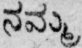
ನಮ್ಮ
